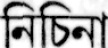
নিচিনা
